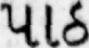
પાઠ
